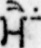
ਮੈਂ
